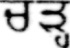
ਚੜ੍ਹ
